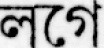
লগে
